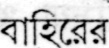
বাহিরের
